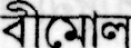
বীমোল
